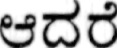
ಆದರೆ
